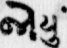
જોયું
